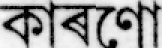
কাৰণো
